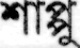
শাপ্পু
